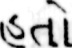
હતો
